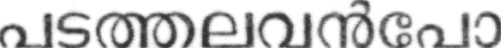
പടത്തലവന്‍പോ
